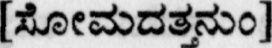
(ಸೋಮದತ್ತನುಂ]
